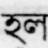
হল
